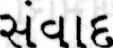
સંવાદ
